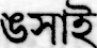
ঙসাই
